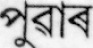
পুৱাৰ
